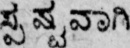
ಸ್ಪಷ್ಟವಾಗಿ
